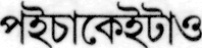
পইচাকেইটাও
